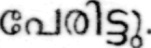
പേരിട്ടു.
